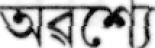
অৱশ্যে
